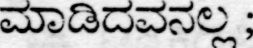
ಮಾಡಿದವನಲ್ಲ;
